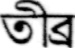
তীব্র
